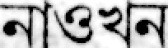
নাওখন
